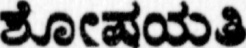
ಶೋಷಯತಿ
